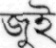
জুই
